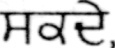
ਸਕਦੇ,
